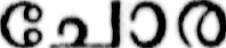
ചോര
